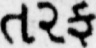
તરફ
